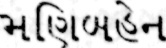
મણિબહેન
